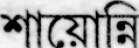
শায়োন্নি
